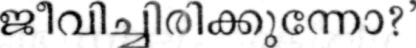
ജീവിച്ചിരിക്കുന്നോ?'
